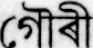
গৌৰী
